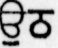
ਉਠ
